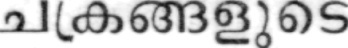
ചക്രങ്ങളുടെ
